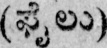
(ಫೈಲು)
